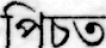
পিচত
